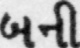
બની
